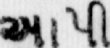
આપી
